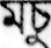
মচু
